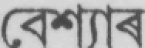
বেশ্যাৰ
